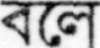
বলে
